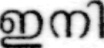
ഇനി
